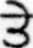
ਤੇ
